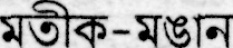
মতীক-মঙান
